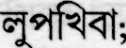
লুপখিবা;
